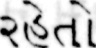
રહેતો
